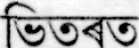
ভিতৰত
